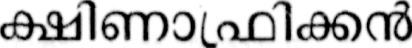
ക്ഷിണാഫ്രിക്കന്‍
